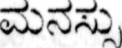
ಮನಸ್ಸು
